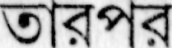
তারপর
